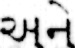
અને
